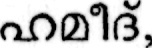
ഹമീദ്,
